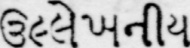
ઉલ્લેખનીય
